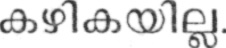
കഴികയില്ല.
